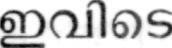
ഇവിടെ
